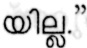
യില്ല."
